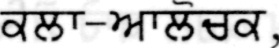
ਕਲਾ-ਆਲੋਚਕ,
